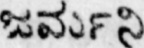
ಜರ್ಮನಿ
